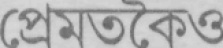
প্ৰেমতকৈও
